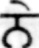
ਨੇ
